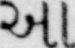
આ
